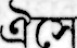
ঐসে
